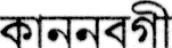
কাননবগী
